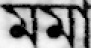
মমা
